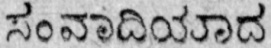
ಸಂವಾದಿಯಾದ
